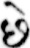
છે
